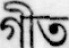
গীত
